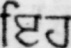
ਇਹ
